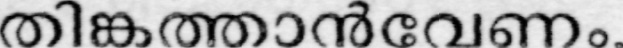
തിങ്കത്താന്‍വേണം.
